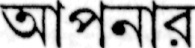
আপনার
